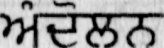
ਅੰਦੋਲਨ
